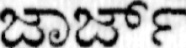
ಜಾರ್ಜ್
